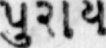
પુરાય
